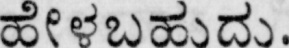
ಹೇಳಬಹುದು.
